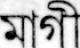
মাগী
